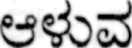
ಆಳುವ
